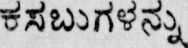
ಕಸಬುಗಳನ್ನು
